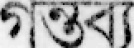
গন্তব্য
